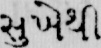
સુખેથી
